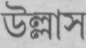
উল্লাস
